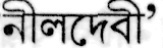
‘নীলদেবী’
